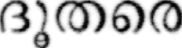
ദൂതരെ
